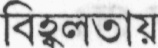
বিহ্বলতায়
